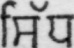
ਸਿੱਧ
